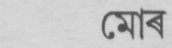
মোৰ
